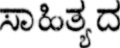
ಸಾಹಿತ್ಯದ
